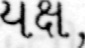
યક્ષ,
